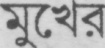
মুখের
